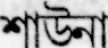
শাউনা
